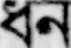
ধন
